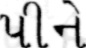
પીને
